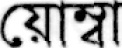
য়োম্বা
